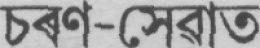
চৰণ-সেৱাত
